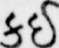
કઈ
